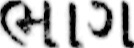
ભાગ
